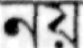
নয়
